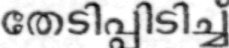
തേടിപ്പിടിച്ച്
